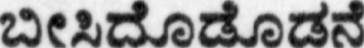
ಬೀಸಿದೊಡೊಡನೆ
